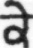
ਕੇ
